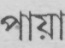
পায়া
